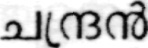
ചന്ദ്രന്‍
